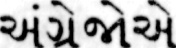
અંગ્રેજોએ
